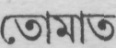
তোমাত
